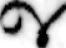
જ
